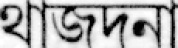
থাজদনা
